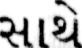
સાથે
